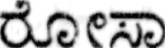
ರೋಸಾ
